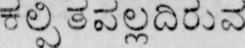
ಕಲ್ಪಿತವಲ್ಲದಿರುವ
